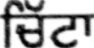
ਚਿੱਟਾ
